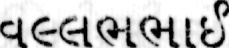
વલ્લભભાઈ
